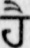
ਹੈ
